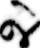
જે
